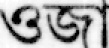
ওজা
